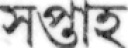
সপ্তাহ
